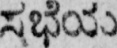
ಸಭೆಯ
